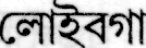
লোইবগা
